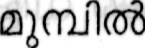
മുമ്പില്‍
